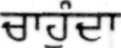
ਚਾਹੁੰਦਾ
